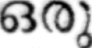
ഒരു
